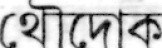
থৌদোক
